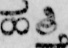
ಹತ್ತಿ
